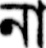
না
